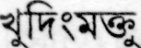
খুদিংমক্তু
